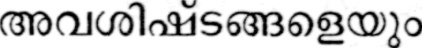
അവശിഷ്ടങ്ങളെയും
